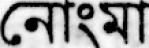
নোংমা
